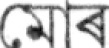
মোৰ
